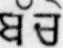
ਬੱਚੇ
